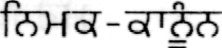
ਨਿਮਕ-ਕਾਨੂੰਨ
